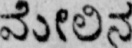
ಮೇಲಿನ
